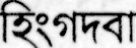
হিংগদবা
